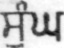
ਸੁੰਘ
